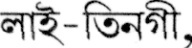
লাই-তিনগী,
